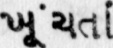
ખૂંચતાં
